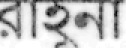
রাহূনা
